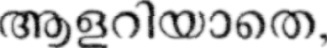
ആളറിയാതെ,
